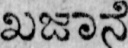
ಖಜಾನೆ
